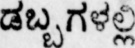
ಡಬ್ಬಗಳಲ್ಲಿ
